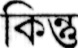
কিন্তু
